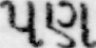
પણ
